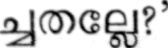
ച്ചതല്ലേ?'
